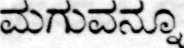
ಮಗುವನ್ನೂ
